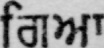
ਗਿਆ
